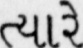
ત્યારે
